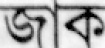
জাক
